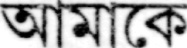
আমাকে
